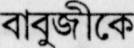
বাবুজীকে
